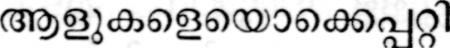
ആളുകളെയൊക്കെപ്പറ്റി
